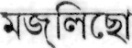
মজ্‌লিছো
